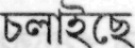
চলাইছে
